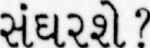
સંઘરશે?
